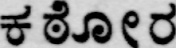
ಕಠೋರ
